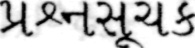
પ્રશ્નસૂચક
